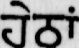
ਹੇਠਾਂ
